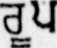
ਰੂਪ
